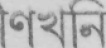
ণখনি
